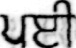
ਪਈ
